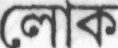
লোক
